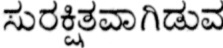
ಸುರಕ್ಷಿತವಾಗಿಡುವ
